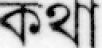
কথা
